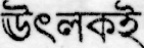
ঊৎলকই
